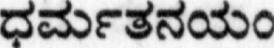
ಧರ್ಮತನಯಂ
